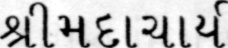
શ્રીમદાચાર્ય
